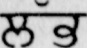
ਲੱਭ
